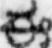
ಈ
